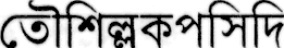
তৌশিল্লকপসিদি
